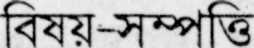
বিষয়-সম্পত্তি
